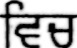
ਵਿਚ
